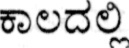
ಕಾಲದಲ್ಲಿ
